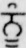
ਨੂੰ
